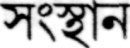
সংস্থান
